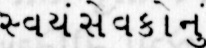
સ્વયંસેવકોનું
